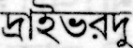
দ্রাইভরদু
